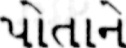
પોતાને
